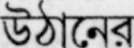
উঠানের
